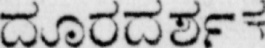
ದೂರದರ್ಶಕ
